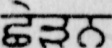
ਛੇੜਨ
